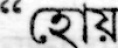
“হোয়
